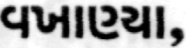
વખાણ્યા,
